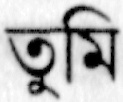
তুমি
